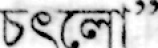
চৎলো”
